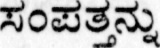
ಸಂಪತ್ತನ್ನು
